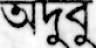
অদুবু
